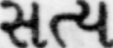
સત્ય
